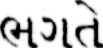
ભગતે
